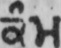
ਕੰਮ
